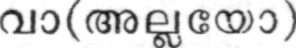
വാ(അല്ലയോ)
